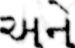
અને
